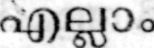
എല്ലാം
